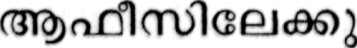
ആഫീസിലേക്കു
